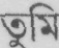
তুমি
